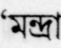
‘মন্দ্রা
